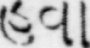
હવા
